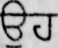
ਉਹ
